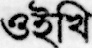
ওইখি
